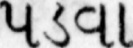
પડવા
